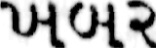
ખબર
